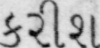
કરીશ
